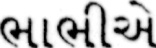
ભાભીએ
